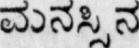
ಮನಸ್ಸಿನ
